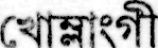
খোম্লাংগী
